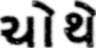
ચોથે
